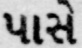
પાસે
